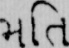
મતિ
